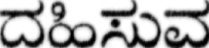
ದಹಿಸುವ
